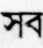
সব
